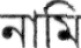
নামি
